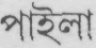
পাইলা
